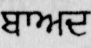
ਬਾਅਦ
